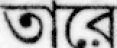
তারে
